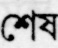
শেষ
